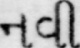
નવી
